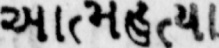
આત્મહત્યા
